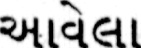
આવેલા
